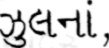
ઝુલનાં,
